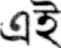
এই
